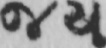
જય
